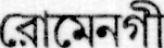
রোমেনগী
